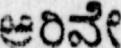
ಅರಿವೇ
